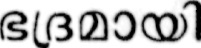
ഭദ്രമായി
